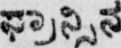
ಫ್ರಾನ್ಸಿನ
